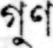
গুণ
